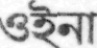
ওইনা
